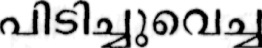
പിടിച്ചുവെച്ച
